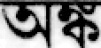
অঙ্ক
